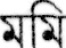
মমি
